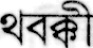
থবক্কী
